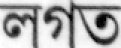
লগত
